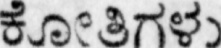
ಕೋತಿಗಳು
